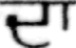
ਦਾ
